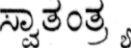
ಸ್ವಾತಂತ್ರ್ಯ
